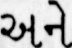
અને
